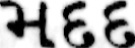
મદદ
